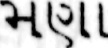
મણા
